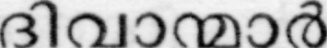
ദിവാന്മാര്‍
